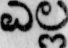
ಎಲ್ಲ
